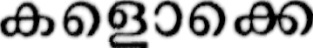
കളൊക്കെ
